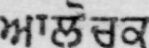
ਆਲੋਚਕ
